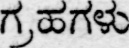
ಗ್ರಹಗಳು
